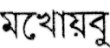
মখোয়বু
